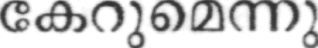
കേറുമെന്നു
